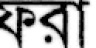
ফরা
